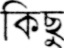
কিছু
